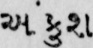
અંકુશ
